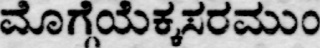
ಮೊಗ್ಗೆಯೆಕ್ಕಸರಮುಂ
